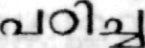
പഠിച്ച
